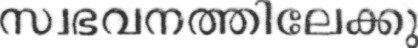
സ്വഭവനത്തിലേക്കു
